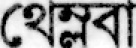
থেম্লবা
